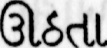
ઊઠતા
